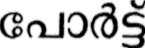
പോര്‍ട്ട്
